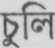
চুলি
